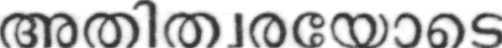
അതിത്വരയോടെ
